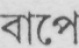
বাপে
